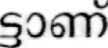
ട്ടാണ്
